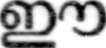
ഈ
